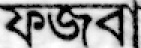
ফজবা
